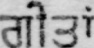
ਗੀਤਾਂ
